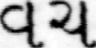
વચ
